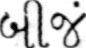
બીજં
